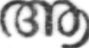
ആ
